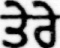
ਤੇਰੇ
